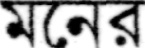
মনের
